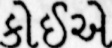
કોઈએ
